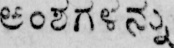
ಅಂಶಗಳನ್ನು
